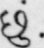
છું.
